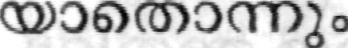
യാതൊന്നും
